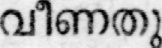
വീണതു
